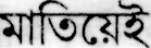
মাতিয়েই
